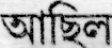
আছিল
